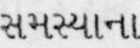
સમસ્યાના
